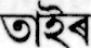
তাইৰ
